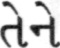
તેને
